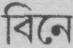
বিনে
